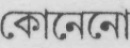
কোনেনো
